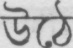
উঠে
